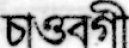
চাওবগী
